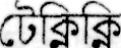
টেক্লিক্নি
